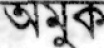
অমুক
